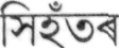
সিহঁতৰ
